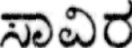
ಸಾವಿರ
